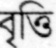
বৃত্তি
